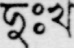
দুঃখ
